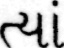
ત્યાં
